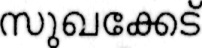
സുഖക്കേട്
